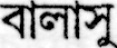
বালাসু
